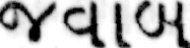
જવાબ
